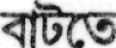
বাটতে
